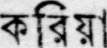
করিয়া
